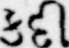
કદી
